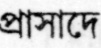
প্রাসাদে
